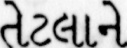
તેટલાને
